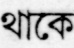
থাকে
